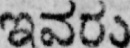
ಇವರು
